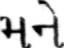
મને
